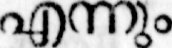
എന്നും
